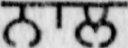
ਨਾਲ
